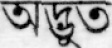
অদ্ভুত
